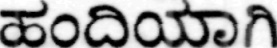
ಹಂದಿಯಾಗಿ
